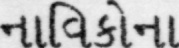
નાવિકોના
